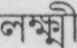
লক্ষ্মী
